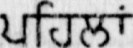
ਪਹਿਲਾਂ
